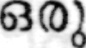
ഒരു
